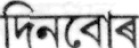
দিনবোৰ
